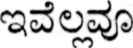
ಇವೆಲ್ಲವೂ
